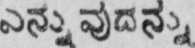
ಎನ್ನುವುದನ್ನು
